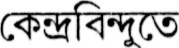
কেন্দ্রবিন্দুতে
